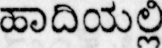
ಹಾದಿಯಲ್ಲಿ
